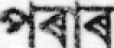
পৰাৰ
